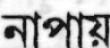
নাপায়
